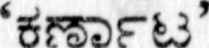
‘ಕರ್ಣಾಟ’
